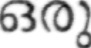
ഒരു
